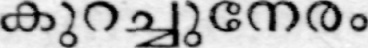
കുറച്ചുനേരം
